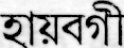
হায়বগী
